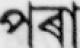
পৰা
